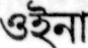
ওইনা
